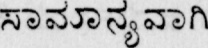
ಸಾಮಾನ್ಯವಾಗಿ
